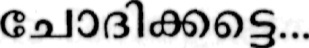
ചോദിക്കട്ടെ...
